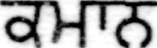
ਕਮਾਨ
